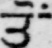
ਤੋਂ
